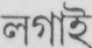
লগাই
